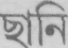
ছানি
